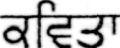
ਕਵਿਤਾ
